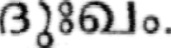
ദുഃഖം.
